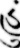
હું
